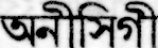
অনীসিগী
